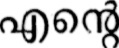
എന്റെ
